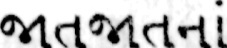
જાતજાતનાં
